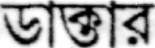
ডাক্তার
